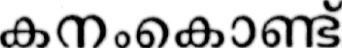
കനംകൊണ്ട്
